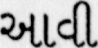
આવી
